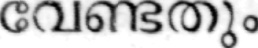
വേണ്ടതും
